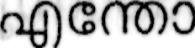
എന്തോ
